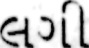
લગી
